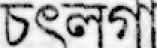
চৎলগা
